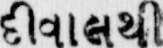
દીવાલથી
